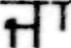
ਜਾ
